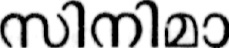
സിനിമാ
